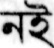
নই
